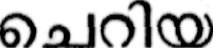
ചെറിയ
